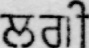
ਲਗੀ
